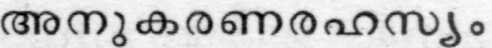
അനുകരണരഹസ്യം
